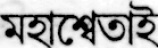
মহাশ্বেতাই
